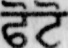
ਫੋਟੋ
